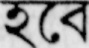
হবে
